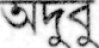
অদুবু
